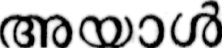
അയാള്‍
